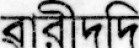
ৱারীদদি
